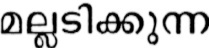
മല്ലടിക്കുന്ന
